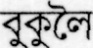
বুকুলৈ
